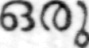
ഒരു
